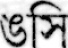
ঙসি
